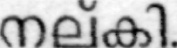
നല്കി.
